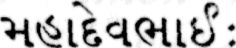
મહાદેવભાઈ:
